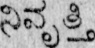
ನಿವೃತ್ತಿ
